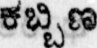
ಕಬ್ಬಿಣ
